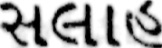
સલાહ
